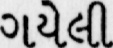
ગયેલી
